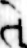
તે
